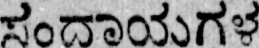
ಸಂದಾಯಗಳ
